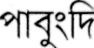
পাবুংদি
